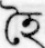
হৈ
